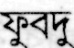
ফুবদু
